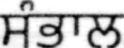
ਸੰਭਾਲ
